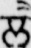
ਲੈ
